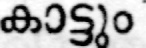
കാട്ടും
